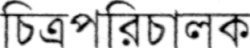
চিত্রপরিচালক
